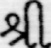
શ્રી
